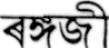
ৰঙ্গজী
